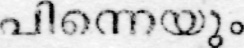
പിന്നെയും
